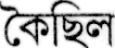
কৈছিল
